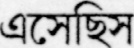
এসেছিস
